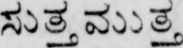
ಸುತ್ತಮುತ್ತ
